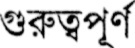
গুরুত্বপূর্ণ
